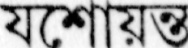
যশোয়ন্ত
